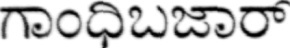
ಗಾಂಧಿಬಜಾರ್
